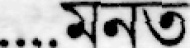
....মনত
